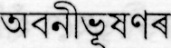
অবনীভূষণৰ
